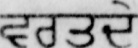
ਵਰਤਦੇ
